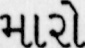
મારો
